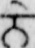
ਨੇ
